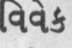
વિવેક
